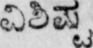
ವಿಶಿಷ್ಟ
